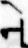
ને
